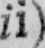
ii)
